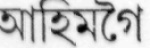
আহিমগৈ
